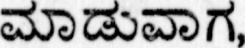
ಮಾಡುವಾಗ,
